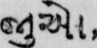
જુઓ,
